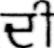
ਦੀ
